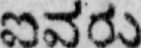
ಐವರು
